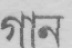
গান
